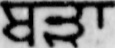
ਬੜਾ
